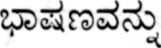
ಭಾಷಣವನ್ನು
